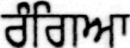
ਰੰਗਿਆ
